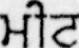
ਮੀਟ
